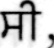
ਸੀ,
